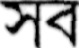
সব
